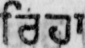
ਰਿਹਾ
